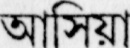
আসিয়া
